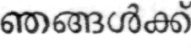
ഞങ്ങള്‍ക്ക്
